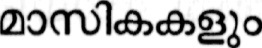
മാസികകളും
